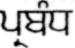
ਪ੍ਰਬੰਧ
